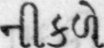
નીકળે
